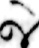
જે
